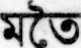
মতৈ
